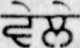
ਵੇਲੇ
